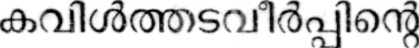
കവിള്‍ത്തടവീര്‍പ്പിന്റെ
